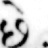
છે.
